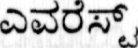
ಎವರೆಸ್ಟ್
